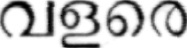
വളരെ
